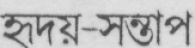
হৃদয়-সন্তাপ
